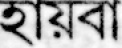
হায়বা
